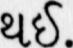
થઈ.
